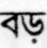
বড়
